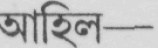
আহিল-
